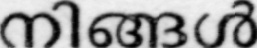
നിങ്ങള്‍
